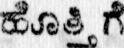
ಹೊತ್ತಿಗೆ
